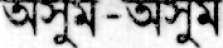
অসুম-অসুম
